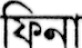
ফিনা
